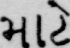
માટે
